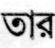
তার
